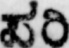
ಪರಿ
